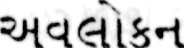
અવલોકન
